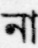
না
